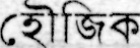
হৌজিক
